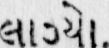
લાગ્યો.
